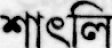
শাৎলি
